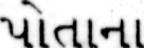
પોતાના
